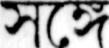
সঙ্গে
